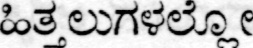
ಹಿತ್ತಲುಗಳಲ್ಲೋ
